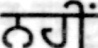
ਨਹੀਂ
